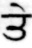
ਤੇ
